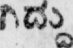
ಗಿದ್ದು
